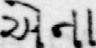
એના
